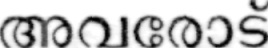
അവരോട്
